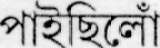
পাইছিলোঁ
